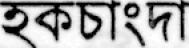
হকচাংদা
